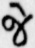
જે
